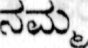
ನಮ್ಮ
